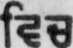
ਵਿਚ
